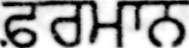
ਫ਼ਰਮਾਨ
